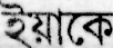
ইয়াকে
